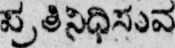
ಪ್ರತಿನಿಧಿಸುವ
